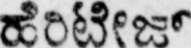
ಹೆರಿಟೇಜ್
